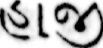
હાજી
